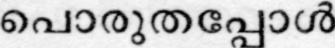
പൊരുതപ്പോള്‍
